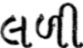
લળી
